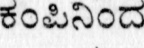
ಕಂಪಿನಿಂದ
